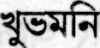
খুভমনি
